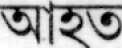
আহত
